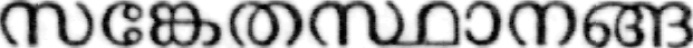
സങ്കേതസ്ഥാനങ്ങ
